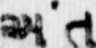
અંત
